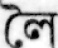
লৈ
